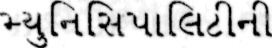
મ્યુનિસિપાલિટીની
